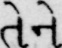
તેને
